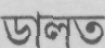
ডালত
